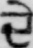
ਦੇ
